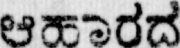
ಆಹಾರದ
